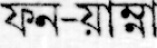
ফন-য়াম্না
